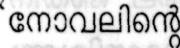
'നോവലിന്റെ
